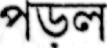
পড়ল
